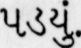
પડયું.
